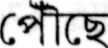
পৌঁছে
